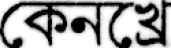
কেনখ্রে
